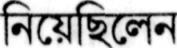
নিয়েছিলেন
